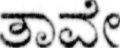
ತಾವೇ
